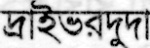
দ্রাইভরদুদা
